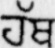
ਹੱਥ
